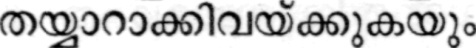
തയ്യാറാക്കിവയ്ക്കുകയും
